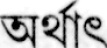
অর্থাৎ
